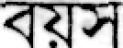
বয়স
